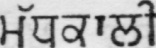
ਮੱਧਕਾਲੀ
